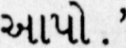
આપો.'
